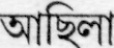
আছিলা
